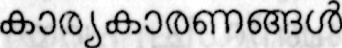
കാര്യകാരണങ്ങള്‍
